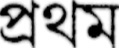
প্রথম
